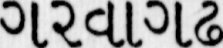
ગરવાગઢ
